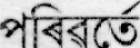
পৰিৱর্তে
